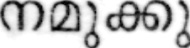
നമുക്കു
